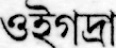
ওইগদ্রা
